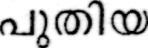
പുതിയ
